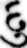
દુ
